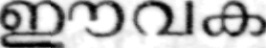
ഈവക
